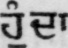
ਹੁੰਦਾ
